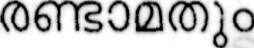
രണ്ടാമതും
